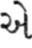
એ
